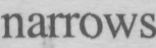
narrows
